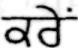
ਕਰੇਂ
